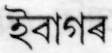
ইবাগৰ
